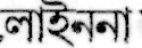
লোইননা
